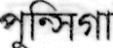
পুন্সিগা
